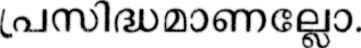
പ്രസിദ്ധമാണല്ലോ.
